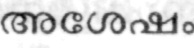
അശേഷം
